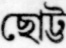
ছোট্ট
